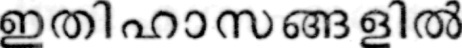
ഇതിഹാസങ്ങളില്‍
